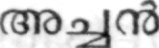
അച്ചന്‍
